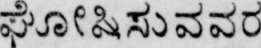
ಘೋಷಿಸುವವರ
